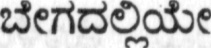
ಬೇಗದಲ್ಲಿಯೇ
